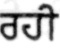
ਰਹੀ
